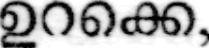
ഉറക്കെ,
